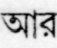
আর
